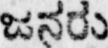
ಜನರು
